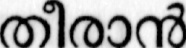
തീരാന്‍
